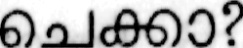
ചെക്കാ?
